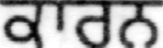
ਕਾਰਨ
